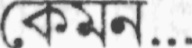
কেমন...
